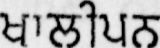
ਖਾਲੀਪਨ
